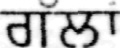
ਗੱਲਾਂ
